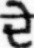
ਦੇ
